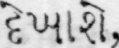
દેખાશે,
